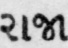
રાજા
